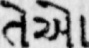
તેઓ
